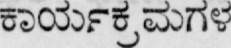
ಕಾರ್ಯಕ್ರಮಗಳ
